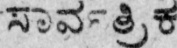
ಸಾರ್ವತ್ರಿಕ
